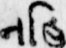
નહિ
